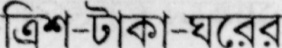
ত্রিশ-টাকা-ঘরের
